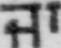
ਜਾ
